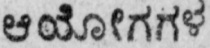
ಆಯೋಗಗಳ
